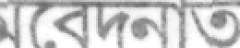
মবেদনাত
